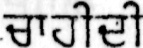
ਚਾਹੀਦੀ
